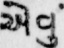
એવું
